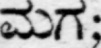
ಮಗ;
